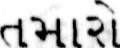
તમારો
